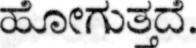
ಹೋಗುತ್ತದೆ.
